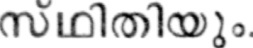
സ്ഥിതിയും.
